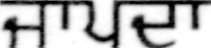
ਜਾਪਦਾ
